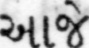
આજે
